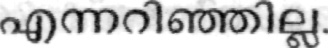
എന്നറിഞ്ഞില്ല.
